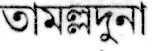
তামল্লদুনা
